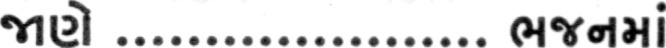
જાણે..............ભજનમાં
